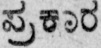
ಪ್ರಕಾರ
